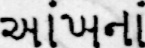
આંખનાં
